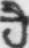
ਹੈ
